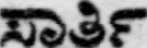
ಸಾರ್ತಿ
